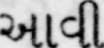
આવી
